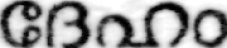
ദേഹം
